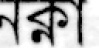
নক্না
